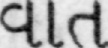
વાત
